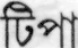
টিপা
